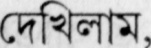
দেখিলাম,
